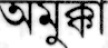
অমুক্কা
